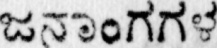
ಜನಾಂಗಗಳ
